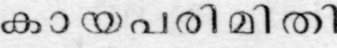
കായപരിമിതി
